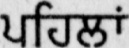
ਪਹਿਲਾਂ
